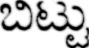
ಬಿಟ್ಟು
